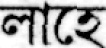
লাহে
